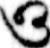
ও
